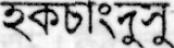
হকচাংদুসু
